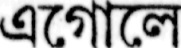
এগোলে
